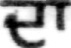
ਦਾ
